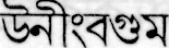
উনীংবগুম
